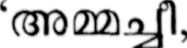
‘അമ്മച്ചീ,
